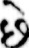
છે
